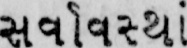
સર્વાવસ્થાં
